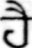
ਹੈ
